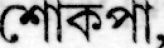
শোকপা,
